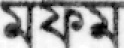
মফম
